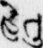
હેતુ
